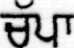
ਚੱਪਾ
